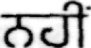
ਨਹੀਂ
